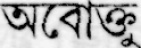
অবোক্তু
